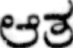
ಆತ
